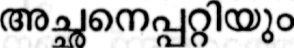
അച്ഛനെപ്പറ്റിയും
